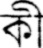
কী
